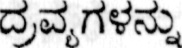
ದ್ರವ್ಯಗಳನ್ನು
